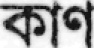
কাণ
